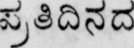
ಪ್ರತಿದಿನದ
